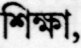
শিক্ষা,
